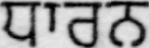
ਧਾਰਨ
